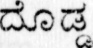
ದೊಡ್ಡ
